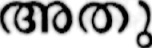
അതു
